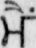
ਮੈਂ
